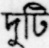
দুটি
